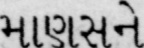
માણસને
